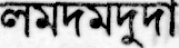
লমদমদুদা
